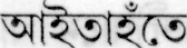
আইতাহঁতে
